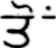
ਤੋਂ
